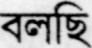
বলছি
